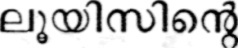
ലൂയിസിന്റെ
